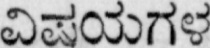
ವಿಷಯಗಳ
